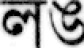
লঙ
